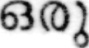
ഒരു
